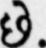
છે.
